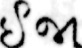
ઈજા
